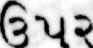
ઉપર
